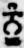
ਨੂੰ
